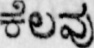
ಕೆಲವು
